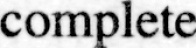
complete
